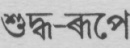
শুদ্ধ-ৰূপে
